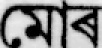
মোৰ
